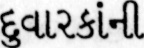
દુવારકાંની
